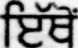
ਇਥੋਂ
